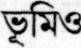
ভূমিও
